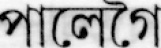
পালেগৈ
